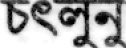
চৎলুনু
